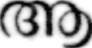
ആ
